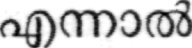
എന്നാല്‍
